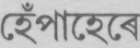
হেঁপাহেৰে
